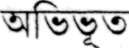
অভিভূত
